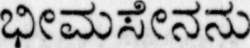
ಭೀಮಸೇನನು
